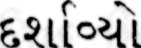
દર્શાવ્યો
